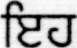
ਇਹ
